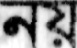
নয়
